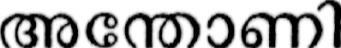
അന്തോണി
